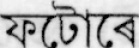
ফটোৰে
